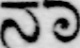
ನಾ
